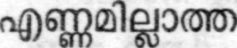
എണ്ണമില്ലാത്ത
